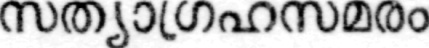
സത്യാഗ്രഹസമരം
